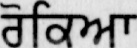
ਰੋਕਿਆ
